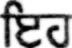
ਇਹ
